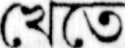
খেতে
